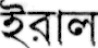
ইরাল
